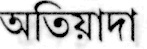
অতিয়াদা
